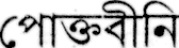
পোক্তবীনি
